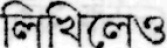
লিখিলেও
